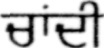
ਚਾਂਦੀ
